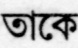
তাকে
